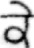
ਕੇ
